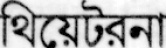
থিয়েটরনা
